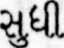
સુધી
